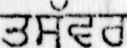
ਤਸੱਵਰ
